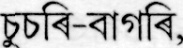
চুচৰি-বাগৰি,
